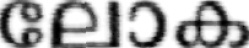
ലോക
